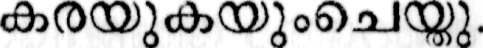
കരയുകയുംചെയ്തു.
